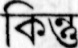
কিন্তু
